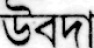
উবদা
